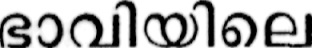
ഭാവിയിലെ
